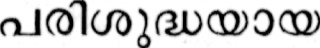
പരിശുദ്ധയായ
